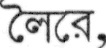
লৈরে,
